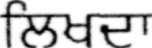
ਲਿਖਦਾ
